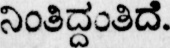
ನಿಂತಿದ್ದಂತಿದೆ.
